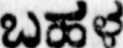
ಬಹಳ
